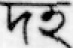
দহ
